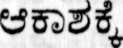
ಆಕಾಶಕ್ಕೆ
